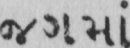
જગમાં
